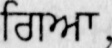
ਗਿਆ,
